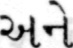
અને
